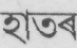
হাতৰ
